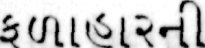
ફળાહારની
